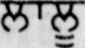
ਲਾਲੂ
